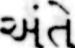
અંતે
